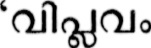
'വിപ്ലവം
